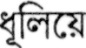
ধূলিয়ে
